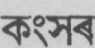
কংসৰ
